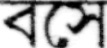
বসে
